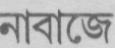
নাবাজে
